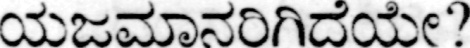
ಯಜಮಾನರಿಗಿದೆಯೇ?
